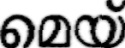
മെയ്
